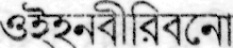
ওইহনবীরিবনো
